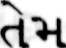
તેમ
